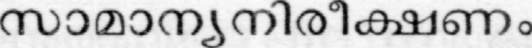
സാമാന്യനിരീക്ഷണം
